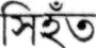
সিহঁত
